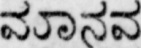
ಮಾನವ
